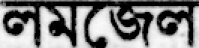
লমজেল
